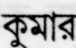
কুমার
